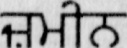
ਜ਼ਮੀਨ
